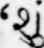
'શું
